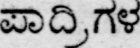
ಪಾದ್ರಿಗಳ
